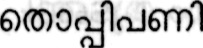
തൊപ്പിപണി
